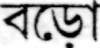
বড়ো
